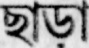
ছাড়া
